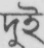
দুই
